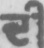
ਦੀ
